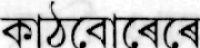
কাঠবোৰেৰে
